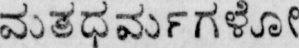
ಮತಧರ್ಮಗಳೋ
